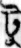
টু
